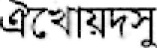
ঐখোয়দসু
